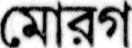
মোরগ
